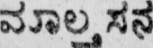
ಮಾಲ್ತಸನ
